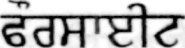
ਫੌਰਸਾਈਟ
